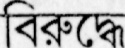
বিরুদ্ধে
